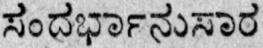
ಸಂದರ್ಭಾನುಸಾರ
